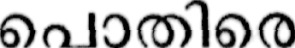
പൊതിരെ
